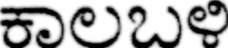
ಕಾಲಬಳಿ
